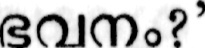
ഭവനം?’
